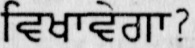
ਵਿਖਾਵੇਗਾ?
